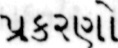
પ્રકરણો
